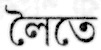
লৈতে
